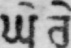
ਘੇਰੇ
